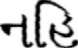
નહિ
